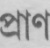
প্ৰাণ
